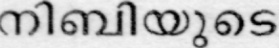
നിബിയുടെ
